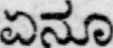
ಏನೂ
